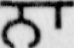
ਨਾ
